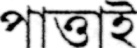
পাত্তাই
